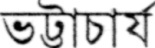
ভট্টাচার্য
